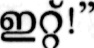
ഇറ്റ്!"
